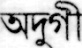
অদুগী
